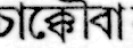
চাক্কৌবা
